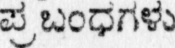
ಪ್ರಬಂಧಗಳು
